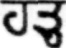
ਹੜ੍ਹ
